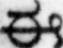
ಈ
